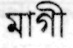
মাগী
